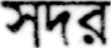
সদর
